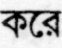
করে
